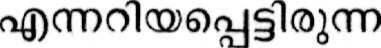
എന്നറിയപ്പെട്ടിരുന്ന
